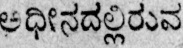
ಅಧೀನದಲ್ಲಿರುವ
